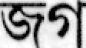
জগ
